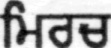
ਮਿਰਚ
